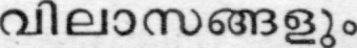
വിലാസങ്ങളും
